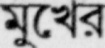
মুখের
